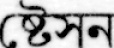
ষ্টেসন
